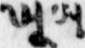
ખૂબ
